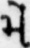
મેં
